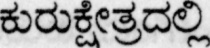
ಕುರುಕ್ಷೇತ್ರದಲ್ಲಿ
